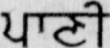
ਪਾਣੀ
